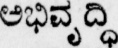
ಅಭಿವೃದ್ಧಿ
